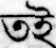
তই
